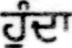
ਹੁੰਦਾ
